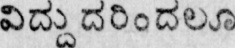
ವಿದ್ದುದರಿಂದಲೂ
